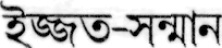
ইজ্জত-সন্মান
